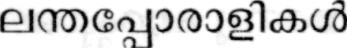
ലന്തപ്പോരാളികള്‍
